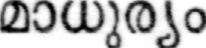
മാധുര്യം
